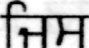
ਜਿਸ
